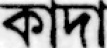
কাদা
